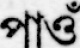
পাওঁ
